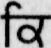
ਕਿ
